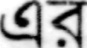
এর
